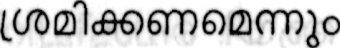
ശ്രമിക്കണമെന്നും
